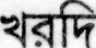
খরদি
